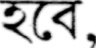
হবে,
